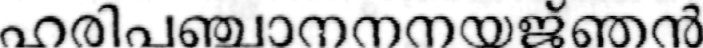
ഹരിപഞ്ചാനനനയജ്ഞന്‍
